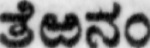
ತೆಱನಂ
